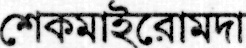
শেকমাইরোমদা
